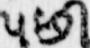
પછી
